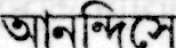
আনন্দিসে
